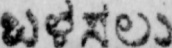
ಬಳಸಲು
